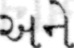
અને
